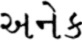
અનેક
